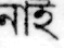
নাই
